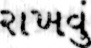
રાખવું
